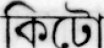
কিটো
